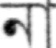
না
